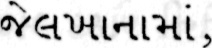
જેલખાનામાં,
